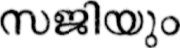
സജിയും
